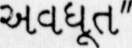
અવધૂત"
